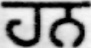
ਹਨ
